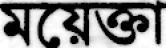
ময়েক্তা
